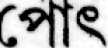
পোৎ
